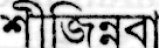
শীজিন্নবা
